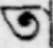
তা
